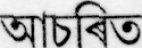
আচৰিত
